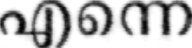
എന്നെ
